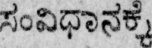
ಸಂವಿಧಾನಕ್ಕೆ
